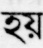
হয়
